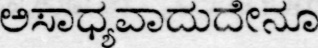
ಅಸಾಧ್ಯವಾದುದೇನೂ
